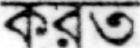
করত
